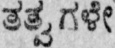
ತತ್ವಗಳೇ
